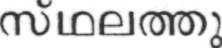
സ്ഥലത്തു
